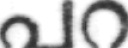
പറ
